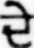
ਦੇ
